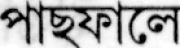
পাছফালে
